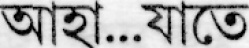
আহা...যাতে
